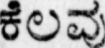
ಕೆಲವು
